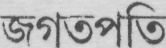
জগতপতি
